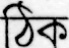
ঠিক
